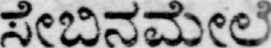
ಸೇಬಿನಮೇಲೆ
